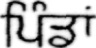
ਪਿੰਡਾਂ
